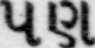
પણ
